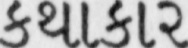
કથાકાર
